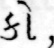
કો,
